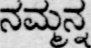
ನಮ್ಮನ್ನ
